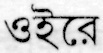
ওইরে
